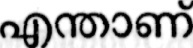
എന്താണ്
